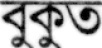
বুকুত
